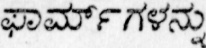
ಫಾರ್ಮ್‌ಗಳನ್ನು
